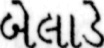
બેલાડે
